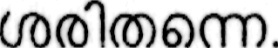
ശരിതന്നെ.
